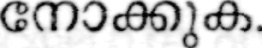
നോക്കുക.
